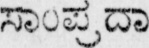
ಸಾಂಪ್ರದಾ
